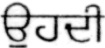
ਉਹਦੀ
